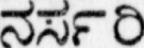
ನರ್ಸರಿ
